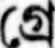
গ্রে
